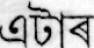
এটাৰ
